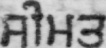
ਸੀਮਤ
